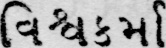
વિશ્વકર્મા
